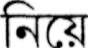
নিয়ে
